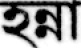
হন্না
